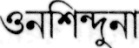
ওনশিন্দুনা
